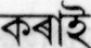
কৰাই
